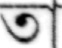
তা
